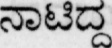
ನಾಟಿದ್ದ
